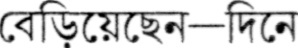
বেড়িয়েছেন–দিনে
